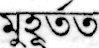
মুহূর্তত
